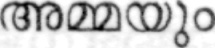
അമ്മയും
